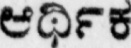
ಆರ್ಥಿಕ
